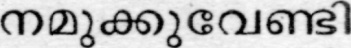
നമുക്കുവേണ്ടി
